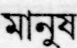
মানুষ
